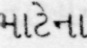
માટેના
